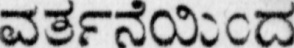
ವರ್ತನೆಯಿಂದ
